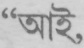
"আই,
